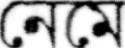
নেমে
